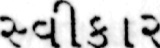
સ્વીકાર
